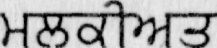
ਮਲਕੀਅਤ
